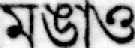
মঙাও
